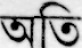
অতি
